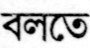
বলতে
